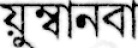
য়ুম্বানবা
